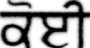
ਕੋਈ
